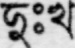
দুঃখ
